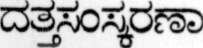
ದತ್ತಸಂಸ್ಕರಣಾ
